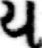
ય
